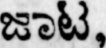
ಜಾಟ,
